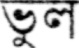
ভুল
